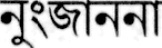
নুংজাননা
